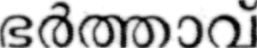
ഭര്‍ത്താവ്
